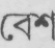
বেশ
